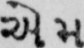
એમ
